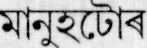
মানুহটোৰ
